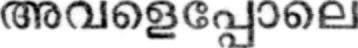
അവളെപ്പോലെ
